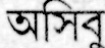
অসিবু
